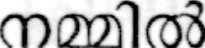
നമ്മില്‍
